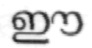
ഈ
